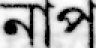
নাপ
